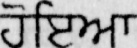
ਹੋਇਆ
